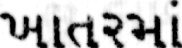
ખાતરમાં
